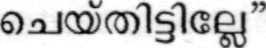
ചെയ്തിട്ടില്ലേ"
